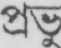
প্রভু
